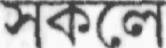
সকলে
